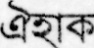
ঐহাক
